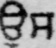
ਉਸ
